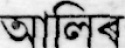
আলিৰ
